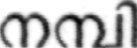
നമ്പി
